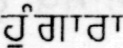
ਹੁੰਗਾਰਾ
